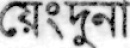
য়েংদুনা
